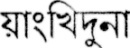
য়াংখিদুনা
